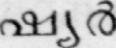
ഷ്യര്‍
